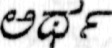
ಅರ್ಥ
